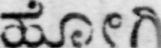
ಹೋಗಿ
